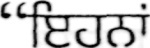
''ਇਹਨਾਂ
